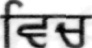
ਵਿਚ
